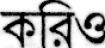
করিও
